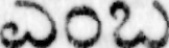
ಎಂಬ
